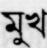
মুখ
